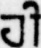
ਹੀ
